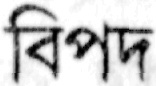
বিপদ
